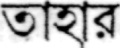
তাহার
